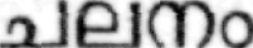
ചലനം
